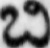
ಬಿ
